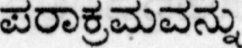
ಪರಾಕ್ರಮವನ್ನು
